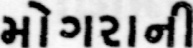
મોગરાની
